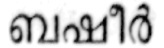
ബഷീര്‍
